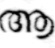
ആ
